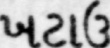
ખટાઉ
